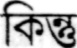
কিন্তু
